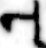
ન
